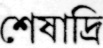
শেষাদ্রি
